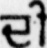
ਦੀ
